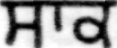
ਸਾਕ
